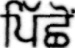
ਪਿੱਛੋਂ
